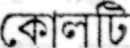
কোলটি
